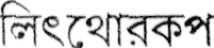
লিৎথোরকপ
